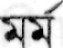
মর্ম
